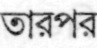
তারপর
